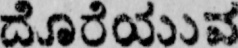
ದೊರೆಯುವ
